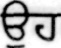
ਉਹ
